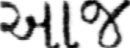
આજ
